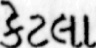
કેટલા
